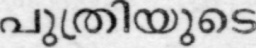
പുത്രിയുടെ
